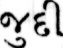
જુદી
